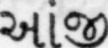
આંજી
